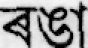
ৰঙা
